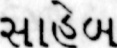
સાહેબ
